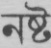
নষ্ট
